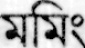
মমিং
